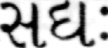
સદ્યઃ
